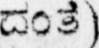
ದಂತೆ)
